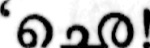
‘ഛെ!
